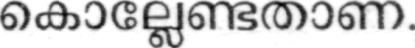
കൊല്ലേണ്ടതാണ.
